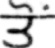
ਤੋਂ
